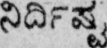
ನಿರ್ದಿಷ್ಟ
